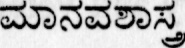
ಮಾನವಶಾಸ್ತ್ರ
